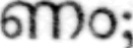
ണം;
